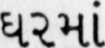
ઘરમાં
